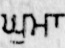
ਘੁਮਾ
